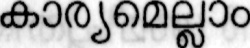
കാര്യമെല്ലാം
